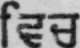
ਵਿਚ
